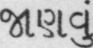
જાણવું
